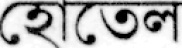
হোতেল
